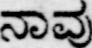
ನಾವು
